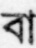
বা
